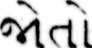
જોતો
